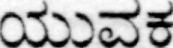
ಯುವಕ
